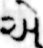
એ
